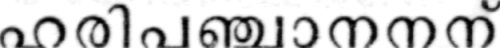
ഹരിപഞ്ചാനനന്
